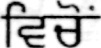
ਵਿਚੋਂ
